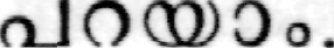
പറയാം.
